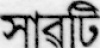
সাৱটি
